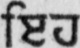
ਇਹ
